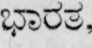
ಭಾರತ,
